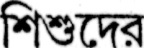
শিশুদের
